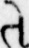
તે
